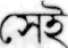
সেই
